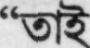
"তাই
